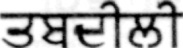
ਤਬਦੀਲੀ
